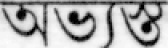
অভ্যস্ত
